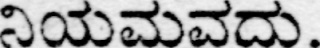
ನಿಯಮವದು.
